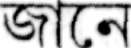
জানে
